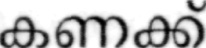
കണക്ക്
